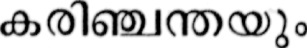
കരിഞ്ചന്തയും
